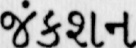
જંકશન
